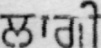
ਲਾਗੀ
